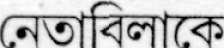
নেতাবিলাকে
